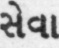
સેવા
